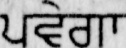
ਪਵੇਗਾ
